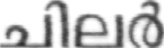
ചിലര്‍
